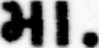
મા.
